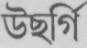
উছৰ্গি
